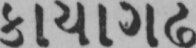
કાયાગઢ
